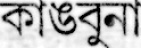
কাঙবুনা
